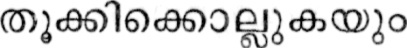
തൂക്കിക്കൊല്ലുകയും
